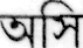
অসি
